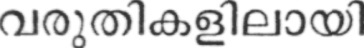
വരുതികളിലായി
